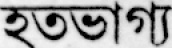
হতভাগ্য
